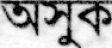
অসুক
